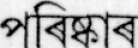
পৰিষ্কাৰ
